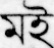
মই
